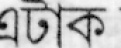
এটাক
